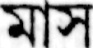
মাস
